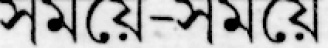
সময়ে-সময়ে
